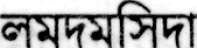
লমদমসিদা
